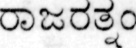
ರಾಜರತ್ನಂ
